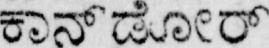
ಕಾನ್‌ಡೋರ್
